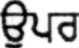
ਉਪਰ
